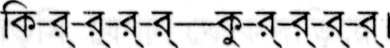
কি-র্-র্-র্-র্–কু-র্-র্-র্-র্।
